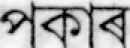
পকাৰ
